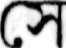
সে
